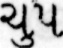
ચુપ
